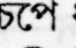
চপে
